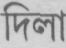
দিলা
